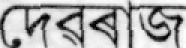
দেৱৰাজ
